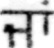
ਜਾਂ
